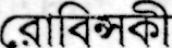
রোবিন্সকী
